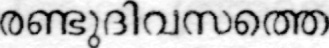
രണ്ടുദിവസത്തെ
